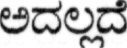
ಅದಲ್ಲದೆ
